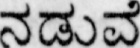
ನಡುವೆ
